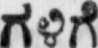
ಗಳಿಗೆ
